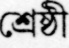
শ্রেষ্ঠী
